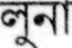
লুনা
